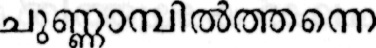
ചുണ്ണാമ്പില്‍ത്തന്നെ
